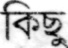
কিছু
